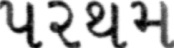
પરથમ
